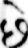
છે
